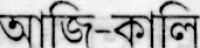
আজি-কালি
